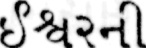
ઈશ્વરની
